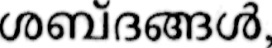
ശബ്ദങ്ങള്‍,
